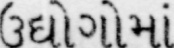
ઉધોગોમાં
